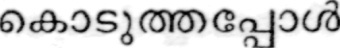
കൊടുത്തപ്പോള്‍
